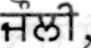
ਜੌਲੀ,
